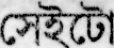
সেইটো
